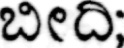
ಬೀದಿ;
